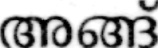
അങ്ങ്
